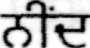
ਨੀਂਦ
